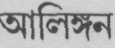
আলিঙ্গন
